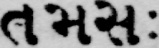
તમસઃ
